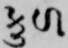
કુળ
